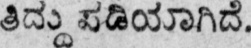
ತಿದ್ದುಪಡಿಯಾಗಿದೆ.
